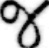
જ
